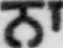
ਨਾ
